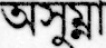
অসুম্না
